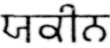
ਯਕੀਨ
